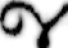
જ
